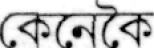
কেনেকৈ
